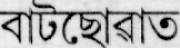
বাটছোৱাত
